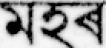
মহৰ
